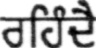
ਰਹਿੰਦੈ
